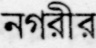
নগরীর
